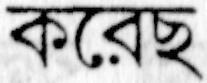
করেছ
